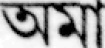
অমা
